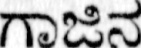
ಗಾಜಿನ
